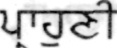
ਪ੍ਰਾਹੁਣੀ
